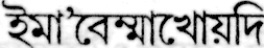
ইমা’বেম্মখোয়দি
